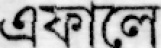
এফালে
